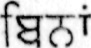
ਬਿਨਾਂ
